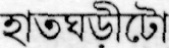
হাতঘড়ীটো
